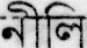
নীলি
